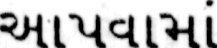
આપવામાં
